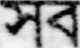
সব
